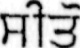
ਸੀਤੋ
